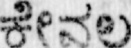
ಕೇವಲ
